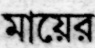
মায়ের
